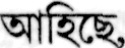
আহিছে,
